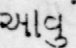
આવું
